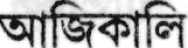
আজিকালি
